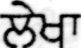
ਲੇਖਾ
